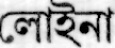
লোইনা
